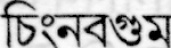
চিংনবগুম
